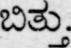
ಬಿತ್ತು.
